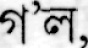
গ'ল,
